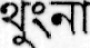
থুংনা
